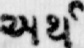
અર્થ
